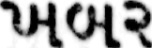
ખબર
